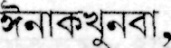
ঈনাকখুনবা,
